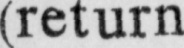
(return
